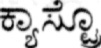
ಕ್ಯಾಸ್ಟ್ರೊ
